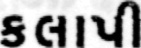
કલાપી
